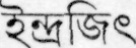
ইন্দ্রজিৎ
